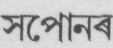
সপোনৰ
